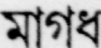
মাগধ
